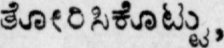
ತೋರಿಸಿಕೊಟ್ಟು,
